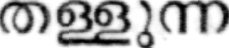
തള്ളുന്ന
